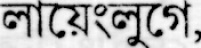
লায়েংলুগে,
